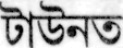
টাউনত
